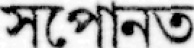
সপোনত
